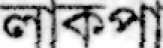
লাকপা
